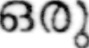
ഒരു
